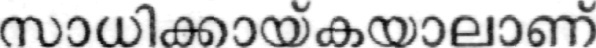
സാധിക്കായ്കയാലാണ്
